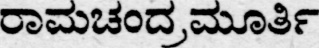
ರಾಮಚಂದ್ರಮೂರ್ತಿ
